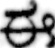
ಈ
